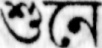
শুনে
